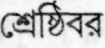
শ্রেষ্ঠিবর
